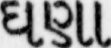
ઘણા
